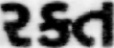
રક્ત
